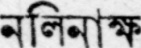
নলিনাক্ষ
